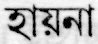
হায়না
